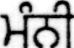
ਮੰਨੀ
